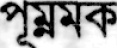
পূম্নমক
